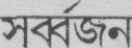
সৰ্ব্বজন
